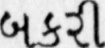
બકરી
